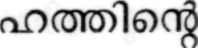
ഹത്തിന്റെ
